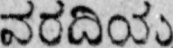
ವರದಿಯ
